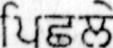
ਪਿਛਲੇ
